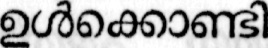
ഉള്‍ക്കൊണ്ടി
